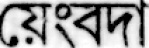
য়েংবদা
